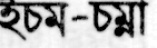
ইচম-চম্না
